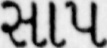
સાપ
